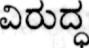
ವಿರುದ್ಧ
